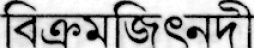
বিক্রমজিৎনদী
